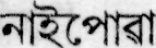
নাইপোৱা
